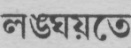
লঙঘয়তে
